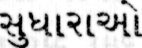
સુધારાઓ
